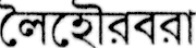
লৈহৌরবরা
